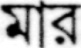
মার
